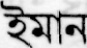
ইমান
